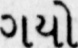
ગયો
